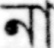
না
